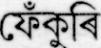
ফেঁকুৰি
